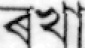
ৰখা
